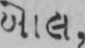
બોલ,
